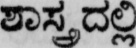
ಶಾಸ್ತ್ರದಲ್ಲಿ
